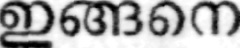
ഇങ്ങനെ
